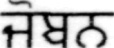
ਜੋਬਨ
